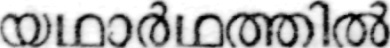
യഥാര്‍ഥത്തില്‍
